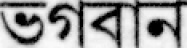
ভগবান
